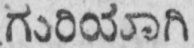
ಗುರಿಯಾಗಿ
